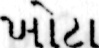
ખોટા
